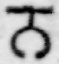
ਨ
